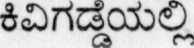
ಕಿವಿಗಡ್ಡೆಯಲ್ಲಿ
